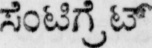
ಸೆಂಟಿಗ್ರೆಟ್
